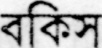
বকিস
